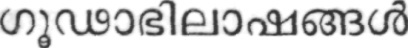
ഗൂഢാഭിലാഷങ്ങള്‍
